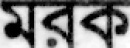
মরক
